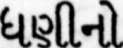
ધણીનો
